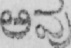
ಅವು
